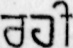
ਰਹੀ
